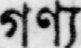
গণ্য
